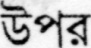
উপর
